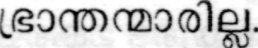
ഭ്രാന്തന്മാരില്ല.
